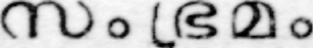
സംഭ്രമം
